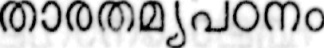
താരതമ്യപഠനം
